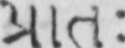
પ્રાતઃ
